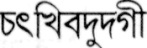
চৎখিবদুদগী
